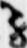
કે
